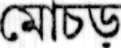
মোচড়
